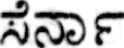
ಸೆರ್ನಾ
